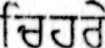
ਚਿਹਰੇ
